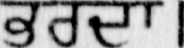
ਭਰਦਾ।
